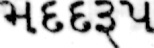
મદદરૂપ
